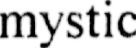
mystic
